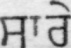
ਸਾਰੇ
